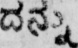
ದನ್ನು
